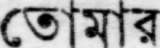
তোমার
